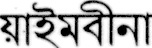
য়াইমবীনা
